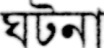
ঘটনা
